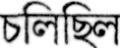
চলিছিল
